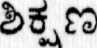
ಶಿಕ್ಷಣ
